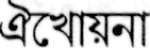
ঐখোয়না
